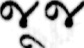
જૂજ
